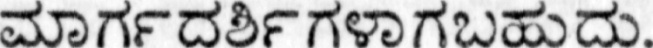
ಮಾರ್ಗದರ್ಶಿಗಳಾಗಬಹುದು.
